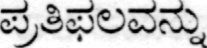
ಪ್ರತಿಫಲವನ್ನು
